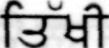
ਤਿੱਖੀ
